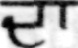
ਦਾ
